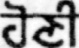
ਹੋਣੀ
